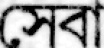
সেবা
